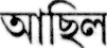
আছিল
